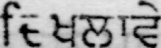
ਦਿਖਲਾਵੇ
